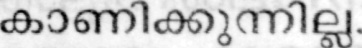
കാണിക്കുന്നില്ല.
